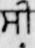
ਸੀ
